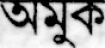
অমুক
